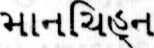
માનચિહ્ન
